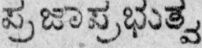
ಪ್ರಜಾಪ್ರಭುತ್ವ
